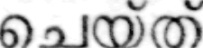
ചെയ്ത്
